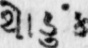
થોડુંક
